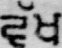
ਵੱਖ
